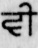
ਵੀ
